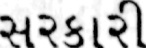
સરકારી
